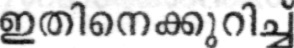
ഇതിനെക്കുറിച്ച്
